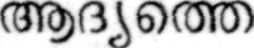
ആദ്യത്തെ
